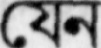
যেন
